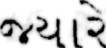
જ્યારે
